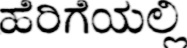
ಹೆರಿಗೆಯಲ್ಲಿ
